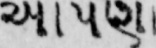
આપણા
